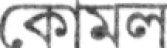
কোমল
